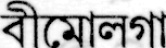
বীমোলগা
